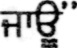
ਜਾਊ''
